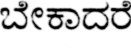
ಬೇಕಾದರೆ
